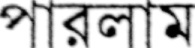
পারলাম
